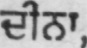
ਦੀਨਾ,
